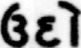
ઉદો
